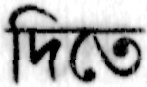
দিতে
